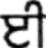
ਈ
